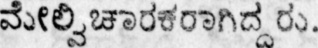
ಮೇಲ್ವಿಚಾರಕರಾಗಿದ್ದರು.
